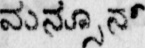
ಮನ್ಸೂನ್
